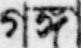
গঙ্গা
